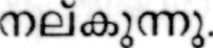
നല്കുന്നു.
